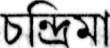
চন্দ্রিমা
